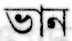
ভান
